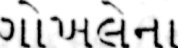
ગોખલેના
